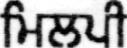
ਮਿਲਪੀ
